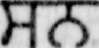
ਸਨ
